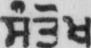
ਸੰਤੋਖ
